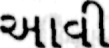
આવી
